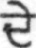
ਦੇ
